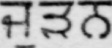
ਜੁੜਨ
